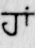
ਹਾਂ
